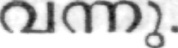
വന്നു.
